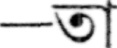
–তা
